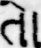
તો
